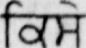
ਕਿਸੇ
